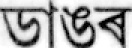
ডাঙৰ
